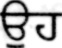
ਉਹ
